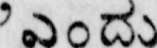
ಎಂದು
